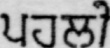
ਪਹਲੀ
